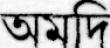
অমদি
